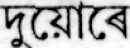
দুয়োৰে
